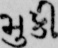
મુકી
